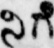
ನಿಗೆ
